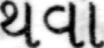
થવા
